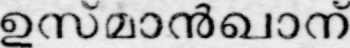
ഉസ്മാന്‍ഖാന്
